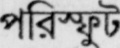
পরিস্ফুট
